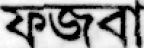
ফজবা
